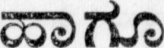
ಹಾಗೂ
